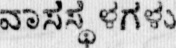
ವಾಸಸ್ಥಳಗಳು
